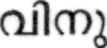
വിനു
